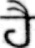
ਹੈ
